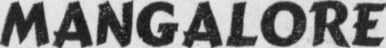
MANGALORE
